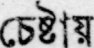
চেষ্টায়
